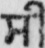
ਸੀ
